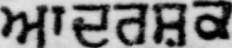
ਆਦਰਸ਼ਕ
